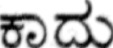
ಕಾದು
